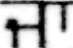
ਜਾ
